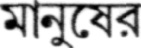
মানুষের
